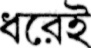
ধরেই
